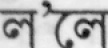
ল'লে
